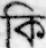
কি
